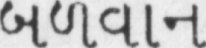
બળવાન
